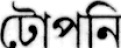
টোপনি
